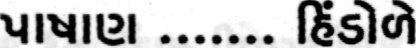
પાષાણ.......હિંડોળે
